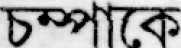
চম্পাকে
